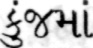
કુંજમાં
